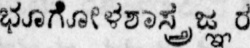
ಭೂಗೋಳಶಾಸ್ತ್ರಜ್ಞರ
